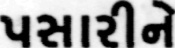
પસારીની
